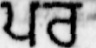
ਪਰ
